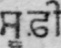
ਸੂਫ਼ੀ
